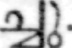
ച്ചു.
